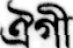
ঐগী
